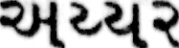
અય્યર
